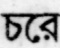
চরে
